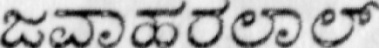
ಜವಾಹರಲಾಲ್
